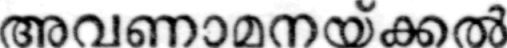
അവണാമനയ്ക്കല്‍
